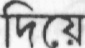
দিয়ে
